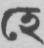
হে
